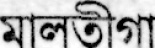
মালতীগা
